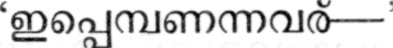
'ഇപ്പെമ്പണന്നവര്-'
